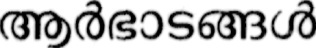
ആര്‍ഭാടങ്ങള്‍
